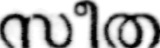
സീത
